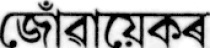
জোঁৱায়েকৰ
